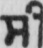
ਸੀ
